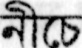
নীচে
